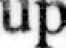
up
